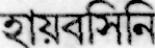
হায়বসিনি
